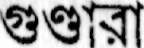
গুণ্ডারা
